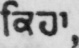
ਕਿਹਾ,
